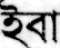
ইবা
